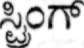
ಸ್ಟ್ರಿಂಗ್
